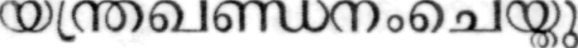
യന്ത്രഖണ്ഡനംചെയ്തു
